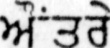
ਔਂਤਰੇ
